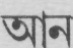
আন
